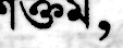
শক্তম,
